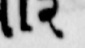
વાર
